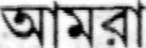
আমরা
